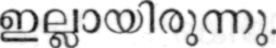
ഇല്ലായിരുന്നു.
